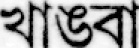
খাঙবা
